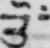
ਤੋਂ
